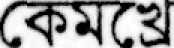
কেমখ্রে
